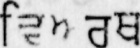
ਵਿਅਰਥ
